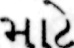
માટે
